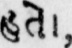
હતો,
